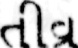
તીવ્ર
